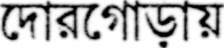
দোরগোড়ায়
